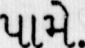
પામે.
